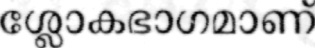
ശ്ലോകഭാഗമാണ്
